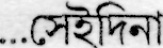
...সেইদিনা
